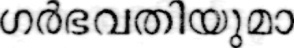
ഗര്‍ഭവതിയുമാ
